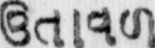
ઉતાવળ
